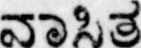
ವಾಸಿತ
